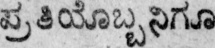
ಪ್ರತಿಯೊಬ್ಬನಿಗೂ
